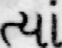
ત્યાં
